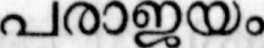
പരാജയം
